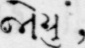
જોયું,
